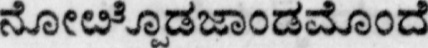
ನೋೞ್ಪೊಡಜಾಂಡಮೊಂದೆ
